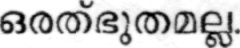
ഒരത്ഭുതമല്ല.
